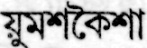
য়ুমশকৈশা
